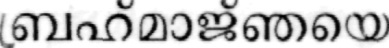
ബ്രഹ്മാജ്ഞയെ
